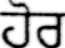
ਹੋਰ
